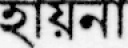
হায়না
